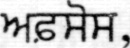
ਅਫ਼ਸੋਸ,
